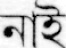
নাই
